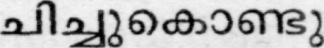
ചിച്ചുകൊണ്ടു
